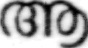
ആ
